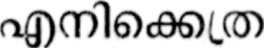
എനിക്കെത്ര
